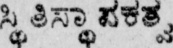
ಸ್ಥಿತಿಸ್ಥಾಪಕತ್ವ
